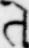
તે
